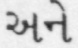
અને
